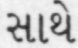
સાથે
